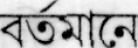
বর্তমানে
